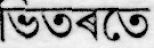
ভিতৰতে
